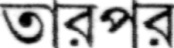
তারপর
